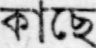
কাছে
